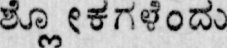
ಶ್ಲೋಕಗಳೆಂದು
